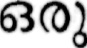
ഒരു
